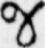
જ
